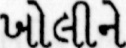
ખોલીને
